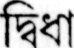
দ্বিধা
